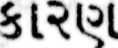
કારણ
